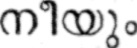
നീയും
